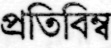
প্রতিবিম্ব
